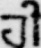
ਹੀ
